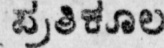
ಪ್ರತಿಕೂಲ
